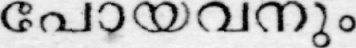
പോയവനും
